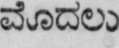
ಮೊದಲು
